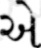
એ
